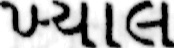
ખ્યાલ
